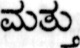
ಮತ್ತು
